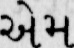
એમ
